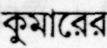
কুমারের
